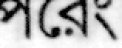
পরেং
